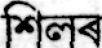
শিলৰ
